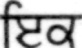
ਇਕ
